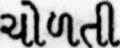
ચોળતી
